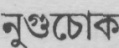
নুগুচোক
